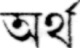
অর্থ
